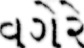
વગેરે
